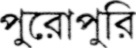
পুরোপুরি
